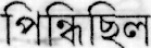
পিন্ধিছিল
